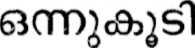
ഒന്നുകൂടി
